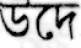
উদে
